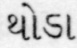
થોડા
